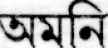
অমনি
